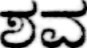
ಶವ
